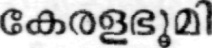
കേരളഭൂമി
